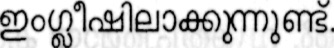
ഇംഗ്ലീഷിലാക്കുന്നുണ്ട്.
